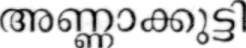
അണ്ണാക്കുട്ടി
